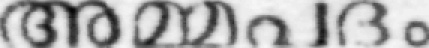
അമ്മപദം
